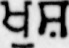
ਖੁਸ਼
